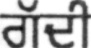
ਗੱਦੀ
